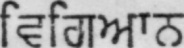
ਵਿਗਿਆਨ
